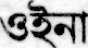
ওইনা
